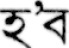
হ'ব
